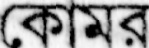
কোমর
